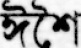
ঈশৈ
